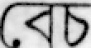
বেচ
